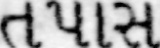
તપાસ
